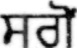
ਸਗੋਂ
